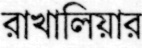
রাখালিয়ার
